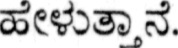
ಹೇಳುತ್ತಾನೆ.
